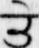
ਤੇ
